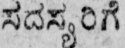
ಸದಸ್ಯರಿಗೆ
